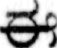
ಈ
